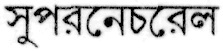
সুপরনেচরেল
